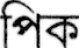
পিক
